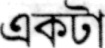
একটা
